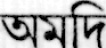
অমদি
